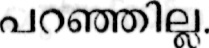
പറഞ്ഞില്ല.
